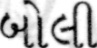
બોલી
